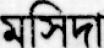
মসিদা
